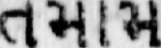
તમામ
